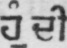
ਹੁੰਦੀ
